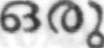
ഒരു
